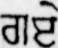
ਗਏ
